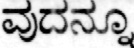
ವುದನ್ನೂ
